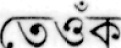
তেওঁক
